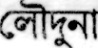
লৌদুনা
